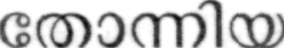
തോന്നിയ
